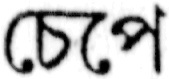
চেপে
